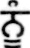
ਨੂੰ
